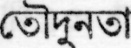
তৌদুনতা
